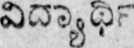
ವಿದ್ಯಾರ್ಥಿ
